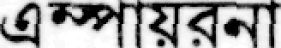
এম্পায়রনা
